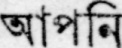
আপনি
